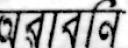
অৱাবনি
